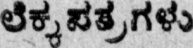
ಲೆಕ್ಕಪತ್ರಗಳು
